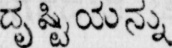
ದೃಷ್ಟಿಯನ್ನು
